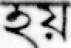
হয়
